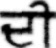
ਦੀ
